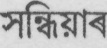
সন্ধিয়াৰ
